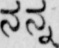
ನನ್ನ
